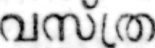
വസ്ത്ര
